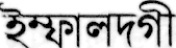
ইম্ফালদগী
